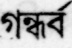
গন্ধর্ব
